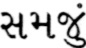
સમજું
